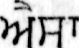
ਐਸਾ
